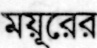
ময়ূরের
